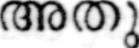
അതു
